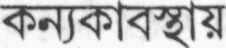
কন্যকাবস্থায়
